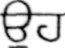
ਉਹ
